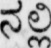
ನಲ್ಲಿ
